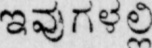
ಇವುಗಳಲ್ಲಿ
